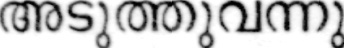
അടുത്തുവന്നു
